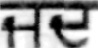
ਜਦ
